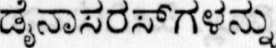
ಡೈನಾಸರಸ್‌ಗಳನ್ನು
